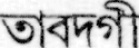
তাবদগী
